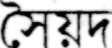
সৈয়দ
